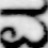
ವ
